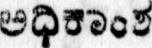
ಅಧಿಕಾಂಶ
